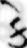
કે
